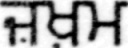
ਜਖ਼ਮ
